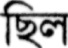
ছিল
